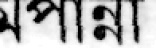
মপান্না
